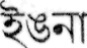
ইঙনা
